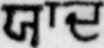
ਯਾਦ
